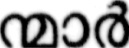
ന്മാര്‍
